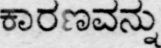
ಕಾರಣವನ್ನು
